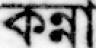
কন্না
